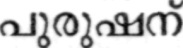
പുരുഷന്
